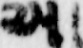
આ
